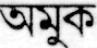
অমুক
